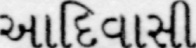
આદિવાસી
